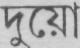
দুয়ো
